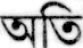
অতি
